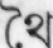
থৈ
